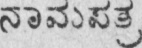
ನಾಮಪತ್ರ
